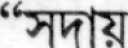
"সদায়
